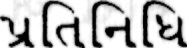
પ્રતિનિધિ
